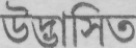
উদ্ভাসিত
